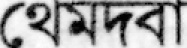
থেমদবা
